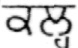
''ਕਲ੍ਹ
